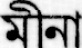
মীনা
